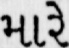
મારે
